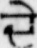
ਦੇ
